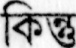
কিন্তু
